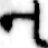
ન
